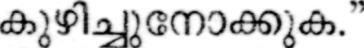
കുഴിച്ചുനോക്കുക.”
